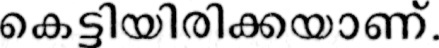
കെട്ടിയിരിക്കയാണ്.
